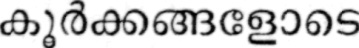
കൂര്‍ക്കങ്ങളോടെ
